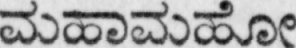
ಮಹಾಮಹೋ
